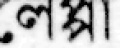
লেপ্পা
